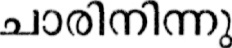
ചാരിനിന്നു
